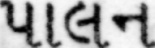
પાલન
